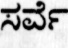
ಸರ್ವೆ
